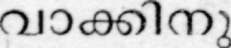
വാക്കിനു
